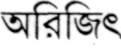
অরিজিৎ
